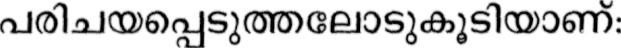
പരിചയപ്പെടുത്തലോടുകൂടിയാണ്:
